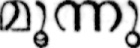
മൂന്നു
